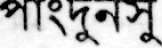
পাংদুনসু
